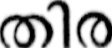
തിര
